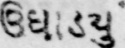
ઉઘાડ્યું
